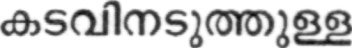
കടവിനടുത്തുള്ള
